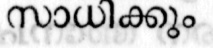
സാധിക്കും
